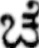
ಚೆ
